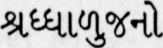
શ્રધ્ધાળુજનો
